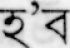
হ'ব
